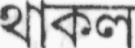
থাকল
